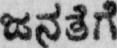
ಜನತೆಗೆ
